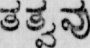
ತತ್ವವು
